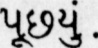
પૂછયું.
